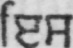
ਇਸ
